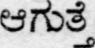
ಆಗುತ್ತೆ
